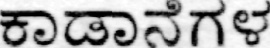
ಕಾಡಾನೆಗಳ
